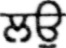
ਲਉ
